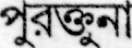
পুরক্তুনা
